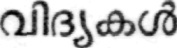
വിദ്യകള്‍
